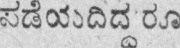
ಪಡೆಯದಿದ್ದರೂ
